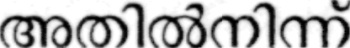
അതില്‍നിന്ന്
